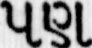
પણ
